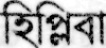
হিপ্লিবা
